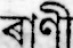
ৰাণী
